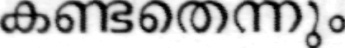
കണ്ടതെന്നും
